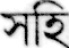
সহি
